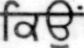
ਕਿਉਂ
